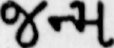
જન્મ
